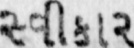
સ્વીકાર
